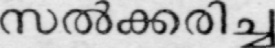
സല്‍ക്കരിച്ച
